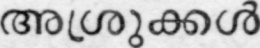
അശ്രുക്കള്‍
